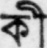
কী
